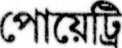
পোয়েট্রি
